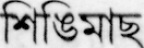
শিঙিমাছ
